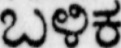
ಬಳಿಕ
